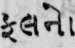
ફલનો
